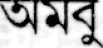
অমবু
